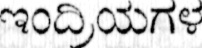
ಇಂದ್ರಿಯಗಳ
